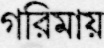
গরিমায়
